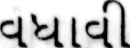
વધાવી
